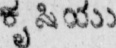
ಕೃಷಿಯು
